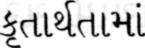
કૃતાર્થતામાં
